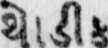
થોડીક
